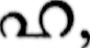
ഹ,
